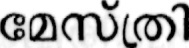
മേസ്ത്രി
